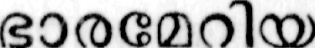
ഭാരമേറിയ
